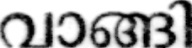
വാങ്ങി
